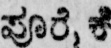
ಪೂರೈಕೆ
